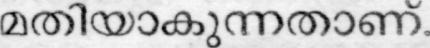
മതിയാകുന്നതാണ്.
